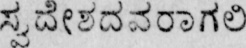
ಸ್ವದೇಶದವರಾಗಲಿ
